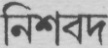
নিশবদ
